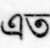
এত
